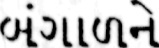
બંગાળને
